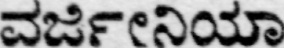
ವರ್ಜೀನಿಯಾ
